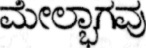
ಮೇಲ್ಭಾಗವು
